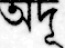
অদূ
